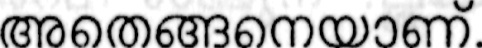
അതെങ്ങനെയാണ്.
